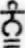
ਨੂੰ
